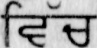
ਵਿੱਚ
